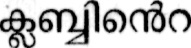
ക്ലബ്ബിന്റെ
